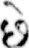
છે
